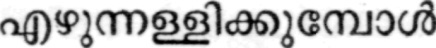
എഴുന്നള്ളിക്കുമ്പോള്‍
